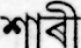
শাৰী
